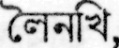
লৈনখি,
